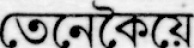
তেনেকৈয়ে
